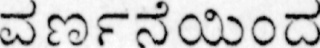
ವರ್ಣನೆಯಿಂದ
